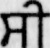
ਸੀ
